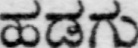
ಹಡಗು
